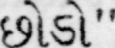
છોડો"
